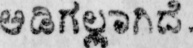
ಅಡಿಗಲ್ಲಾಗಿದೆ.
